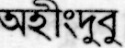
অহীংদুবু
